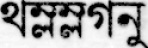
থম্লম্লগনু
